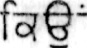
ਕਿਉਂ
